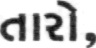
તારો,
